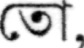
তো,
